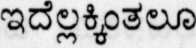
ಇದೆಲ್ಲಕ್ಕಿಂತಲೂ
